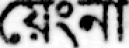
য়েংনা
